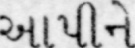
આપીને
